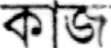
কাজ
